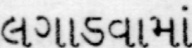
લગાડવામાં
